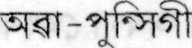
অৱা-পুন্সিগী
